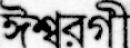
ঈশ্বরগী
